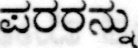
ಪರರನ್ನು
